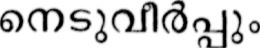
നെടുവീര്‍പ്പും
